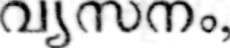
വ്യസനം,
